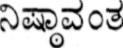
ನಿಷ್ಠಾವಂತ
